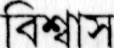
বিশ্বাস
